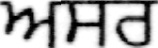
ਅਸਰ
